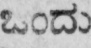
ಒಂದು
